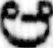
ಆ
